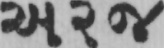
અરજ
